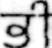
ਭੀ
